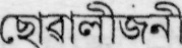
ছোৱালীজনী
